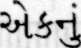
એકનું
